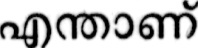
എന്താണ്
